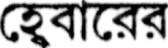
হে্বারের
